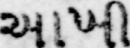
આખી
